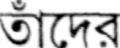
তাঁদের
